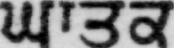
ਘਾਤਕ
